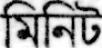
মিনিট
